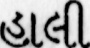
હાલી
